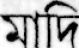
মাদি
